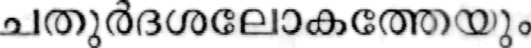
ചതുര്‍ദശലോകത്തേയും
